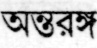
অন্তরঙ্গ
